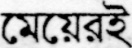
মেয়েরই
